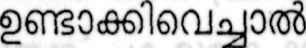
ഉണ്ടാക്കിവെച്ചാല്‍
